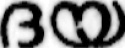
ദയ
